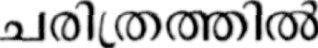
ചരിത്രത്തില്‍
